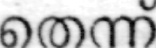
തെന്ന്
